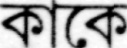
কাকে
